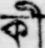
কী
